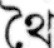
থৈ
